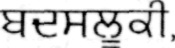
ਬਦਸਲੂਕੀ,
